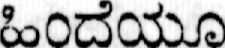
ಹಿಂದೆಯೂ
